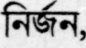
নির্জন,
